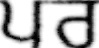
ਪਰ
